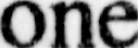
one
